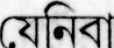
যেনিবা
